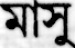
মাসু
